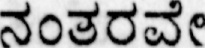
ನಂತರವೇ
